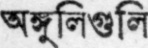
অঙ্গুলিগুলি
